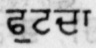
ਫੁਟਦਾ
